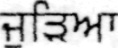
ਜੁੜਿਆ
